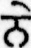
ਨੇ
